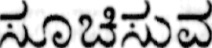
ಸೂಚಿಸುವ
